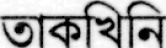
তাকখিনি
